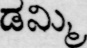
ಡಮ್ಮಿ
